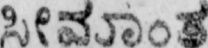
ಸೀಮಾಂತ
